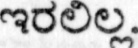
ಇರಲಿಲ್ಲ.
